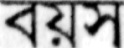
বয়স
